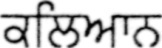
ਕਲਿਆਨ
